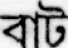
বাট
